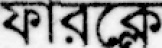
ফারক্লে
